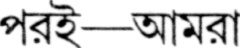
পরই–আমরা
